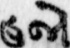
હજો
